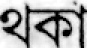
থকা
